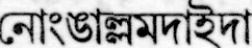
নোংঙাল্লমদাইদা
